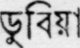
ডুবিয়া
